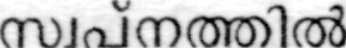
സ്വപ്നത്തില്‍
